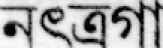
নৎত্রগা
